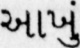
આખું
